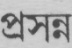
প্ৰসন্ন
